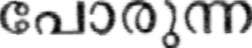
പോരുന്ന
